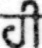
ਹੀ
